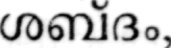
ശബ്ദം,
